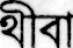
থীবা
